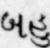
બહુ
